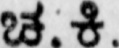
ಚ.ಕಿ.
